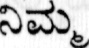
ನಿಮ್ಮ
